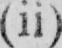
(ii)
